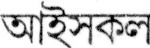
আইসকল
